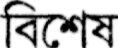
বিশেষ
